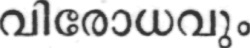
വിരോധവും
